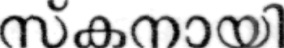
സ്കനായി
